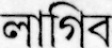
লাগিব
